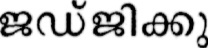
ജഡ്ജിക്കു
